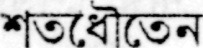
শতধৌতেন
